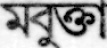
মবুক্তা
